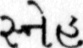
સ્નેહ
